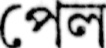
পেল
